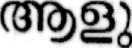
ആളു
